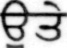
ਉਤੇ
